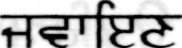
ਜਵਾਇਣ
